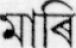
মাৰি
